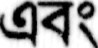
এবং
